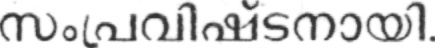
സംപ്രവിഷ്ടനായി.
